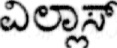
ವಿಲ್ಲಾಸ್
